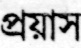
প্রয়াস
